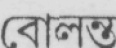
বোলন্ত
